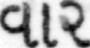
વાર
